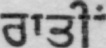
ਰਾਤੀਂ
